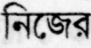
নিজের
